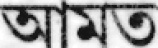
আমত
